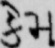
કેમ
